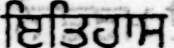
ਇਤਿਹਾਸ
